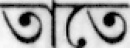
তাতে
